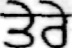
ਤੇਰੇ
